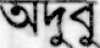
অদুবু
